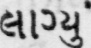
લાગ્યું
